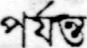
পর্যন্ত
